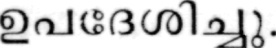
ഉപദേശിച്ചു.
